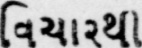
વિચારથી
